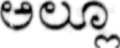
ಅಲ್ಲೂ
